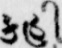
કહી
